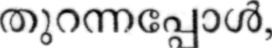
തുറന്നപ്പോള്‍,
